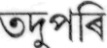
তদুপৰি
